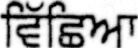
ਵਿੱਛਿਆ
